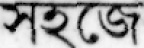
সহজে
